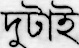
দুটাই
